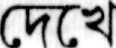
দেখে
